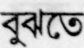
বুঝতে
